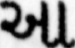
આ
